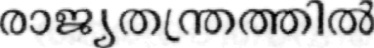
രാജ്യതന്ത്രത്തില്‍
